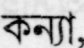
কন্যা,
